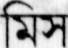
মিস
